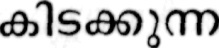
കിടക്കുന്ന
